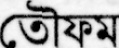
তৌফম
